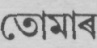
তোমাৰ
